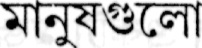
মানুষগুলো
